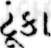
ટૂંકા
